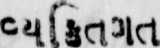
વ્યક્તિગત
